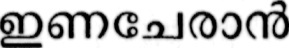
ഇണചേരാന്‍
